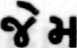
જેમ
